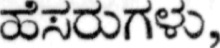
ಹೆಸರುಗಳು,
